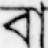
বা
